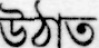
উঠাত
